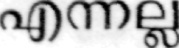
എന്നല്ല
